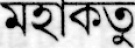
মহাকতু
